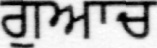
ਗੁਆਚ
